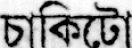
চাকিটো
